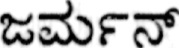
ಜರ್ಮನ್
